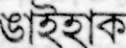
ঙাইহাক
